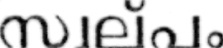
സ്വല്പം
